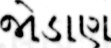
જોડાણ
